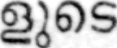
ളുടെ
